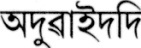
অদুৱাইদদি
